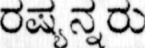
ರಷ್ಯನ್ನರು
